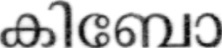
കിബോ
